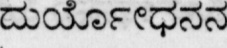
ದುರ್ಯೋಧನನ
